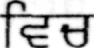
ਵਿਚ
